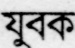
যুবক
